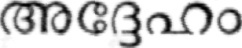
അദ്ദേഹം
